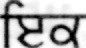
ਇਕ
